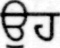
ਉਹ
